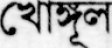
খোঙ্গূল
